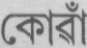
কোৱাঁ
